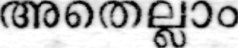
അതെല്ലാം
